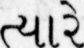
ત્યારે
